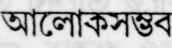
আলোকসম্ভব
